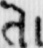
તો
